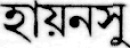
হায়নসু
